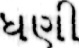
ધણી
